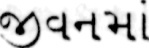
જીવનમાં
